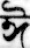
ঈ
